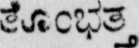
ತೊಂಭತ್ತ
